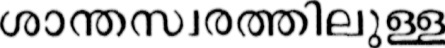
ശാന്തസ്വരത്തിലുള്ള
